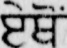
ਏਥੋਂ
